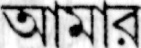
আমার
